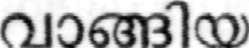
വാങ്ങിയ
